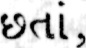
છતાં,
